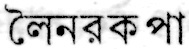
লৈনরকপা
